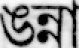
ঙন্না
